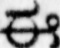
ಈ
